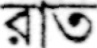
রাত
